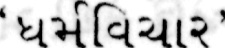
'ધર્મવિચાર'
